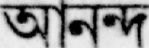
আনন্দ
